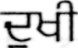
ਦੁਖੀ
